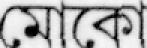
মোকো
